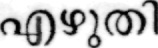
എഴുതി
